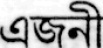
এজনী
